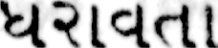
ધરાવતા
